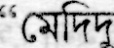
“মেদিদু
